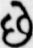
છે
